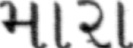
મારા
